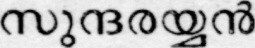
സുന്ദരയ്യന്‍
